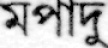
মপাদু
